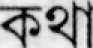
কথা
